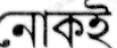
নোকই
